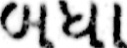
બધા
